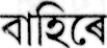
বাহিৰে
